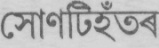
সোণটিহঁতৰ
